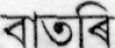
বাতৰি
